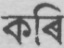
কৰি
